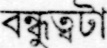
বন্ধুত্বটা
